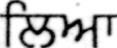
ਲਿਆ
